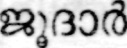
ജൂദാര്‍
